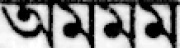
অমমম
